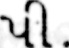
પી.
